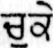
ਚੁੱਕੇ
